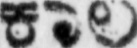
ಕಾಲ
